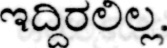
ಇದ್ದಿರಲಿಲ್ಲ.
